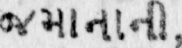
જમાનાની,
